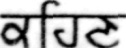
ਕਹਿਣ
